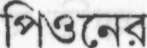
পিওনের
